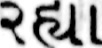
રહ્યા
